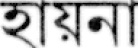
হায়না
